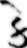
કે
